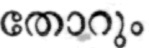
തോറും
